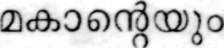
മകാന്റെയും
